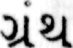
ગ્રંથ
